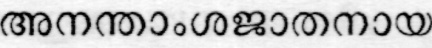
അനന്താംശജാതനായ
